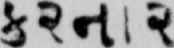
કરનાર
